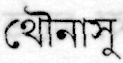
থৌনাসু
